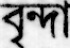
বৃন্দা
